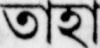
তাহা
